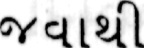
જવાથી
